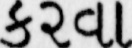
કરવા
